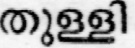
തുള്ളി
